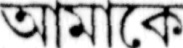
আমাকে
